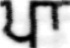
ਪਾ
